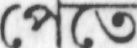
পেতে
